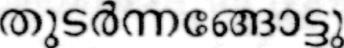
തുടര്‍ന്നങ്ങോട്ടു
